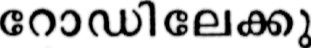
റോഡിലേക്കു
